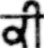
ਕੀ
